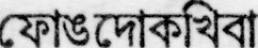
ফোঙদোকখিবা
